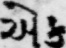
એક
